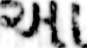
આ
